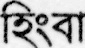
হিংবা
